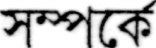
সম্পর্কে
